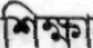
শিক্ষা
